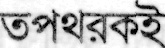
তপথরকই
